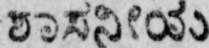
ಶಾಸನೀಯ
